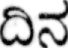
ದಿನ
